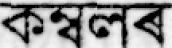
কম্বলৰ
